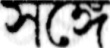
সঙ্গে
